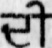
ਦੀ
